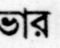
ভার
